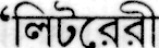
‘লিটরেরী
